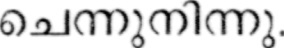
ചെന്നുനിന്നു.
